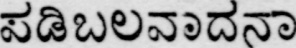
ಪಡಿಬಲವಾದನಾ
